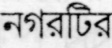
নগরটির
